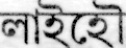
লাইহৌ
